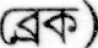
ব্রেক)
